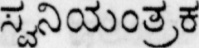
ಸ್ವನಿಯಂತ್ರಕ
